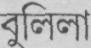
বুলিলা
